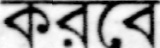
করবে
